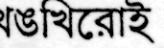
খঙখিরোই
